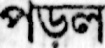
পড়ল
